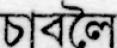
চাবলৈ
